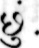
છું.
